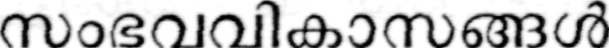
സംഭവവികാസങ്ങള്‍
